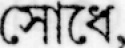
সোধে,
